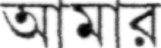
আমার
